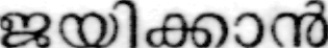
ജയിക്കാന്‍
